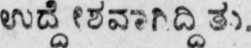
ಉದ್ದೇಶವಾಗಿದ್ದಿತು.
